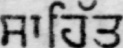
ਸਾਹਿੱਤ
